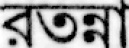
রতন্না
